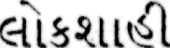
લોકશાહી
